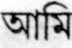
আমি
